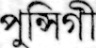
পুন্সিগী
